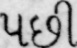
પછી
